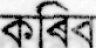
কৰিব
